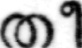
തീ
